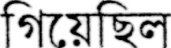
গিয়েছিল
